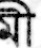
মী
